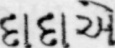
દાદાએ
